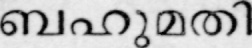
ബഹുമതി
